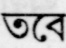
তবে
